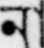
না
